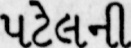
પટેલની
